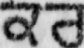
ਕਰ
